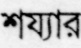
শয্যার
